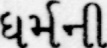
ધર્મની
